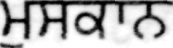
ਮੁਸਕਾਨ
